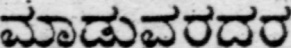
ಮಾಡುವರದರ
